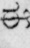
ಈ
